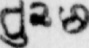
તુચ્છ
